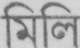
মিলি
